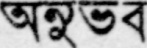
অনুভব
